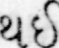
થઈ
